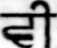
ਵੀ
